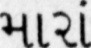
મારાં
